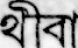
থীবা
